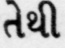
તેથી
